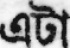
এটা
